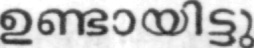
ഉണ്ടായിട്ടു
